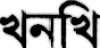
খনখি
